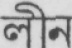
লীন
